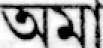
অমা
